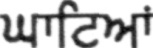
ਘਾਟਿਆਂ
